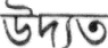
উদ্যত
